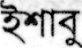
ইশাবু
